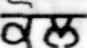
ਕੋਲ
